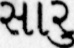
સારુ
